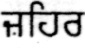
ਜ਼ਹਿਰ
